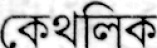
কেথলিক
